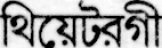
থিয়েটরগী
